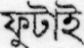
ফুটাই
